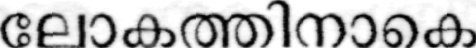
ലോകത്തിനാകെ
